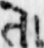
તો
